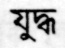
যুদ্ধ
